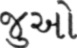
જુઓ
